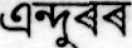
এন্দুৰৰ
